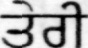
ਤੇਰੀ
